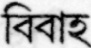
বিবাহ
